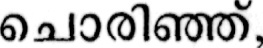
ചൊരിഞ്ഞ്,
